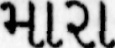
મારા
